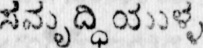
ಸಮೃದ್ಧಿಯುಳ್ಳ
